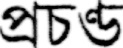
প্রচণ্ড
